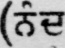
(ਨੰਦ
